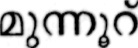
മുന്നൂറ്
